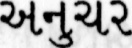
અનુચર
